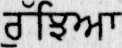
ਰੁੱਝਿਆ
